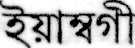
ইয়াম্বগী
